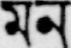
মন
